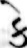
કે
